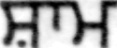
ਸ਼ਾਮ
